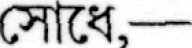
সোধে,-
